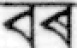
বৰ
